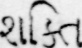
શક્તિ
